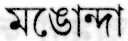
মঙোন্দা
